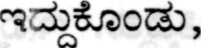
ಇದ್ದುಕೊಂಡು,
